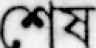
শেষ
